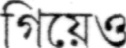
গিয়েও
